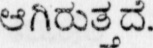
ಆಗಿರುತ್ತದೆ.
